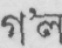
গ'ল
